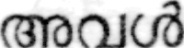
അവള്‍
